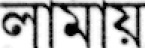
লামায়
